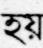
হয়
